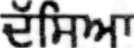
ਦੱਸਿਆ
